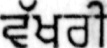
ਵੱਖਰੀ
